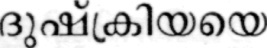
ദുഷ്ക്രിയയെ
